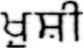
ਖ਼ੁਸ਼ੀ
